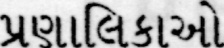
પ્રણાલિકાઓ
